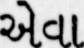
એવા
